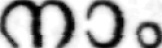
നാം
